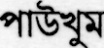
পাউখুম
